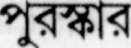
পুরস্কার
